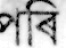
পৰি
